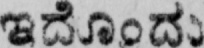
ಇದೊಂದು
